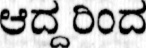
ಆದ್ದರಿಂದ
